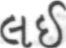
લઈ
